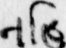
નહિ
